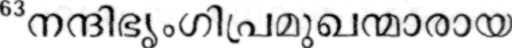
63നന്ദിഭൃംഗിപ്രമുഖന്മാരായ
